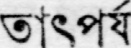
তাৎপর্য
